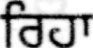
ਰਿਹਾ
